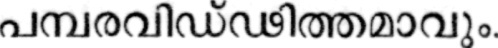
പമ്പരവിഡ്ഢിത്തമാവും.
